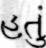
હતું
